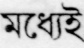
মধ্যেই
